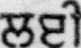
ਲਈ
